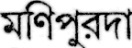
মণিপুরদা
